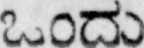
ಒಂದು
